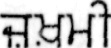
ਜ਼ਖ਼ਮੀ
